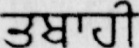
ਤਬਾਹੀ
